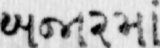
બજારમાં
